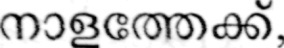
നാളത്തേക്ക്,
